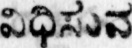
ವಿಧಿಸುವ
